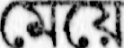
মেয়ে
